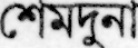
শেমদুনা
